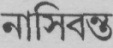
নাসিবন্ত
